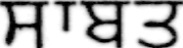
ਸਾਬਤ
